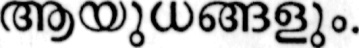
ആയുധങ്ങളും.
